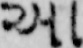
આ
